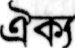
ঐক্য
